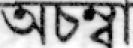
অচম্বা
